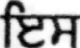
ਇਸ
